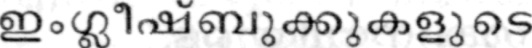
ഇംഗ്ലീഷ്ബുക്കുകളുടെ
